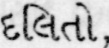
દલિતો,
